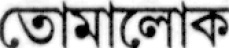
তোমালোক
